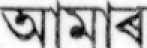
আমাৰ
